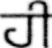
ਹੀ
